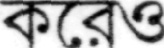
করেও
